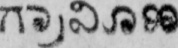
ಗ್ರಾಮೀಣ
